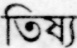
তিষ্য
